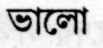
ভালো
